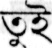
তুই
